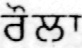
ਰੌਲਾ
